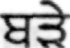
ਬੜੇ
